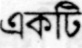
একটি
